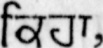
ਕਿਹਾ,
